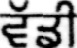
ਵੱਡੀ
